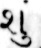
શું
